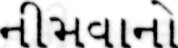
નીમવાનો
